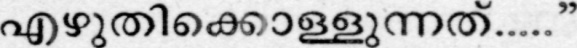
എഴുതിക്കൊള്ളുന്നത്....."
